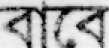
বাবে
